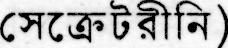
সেক্রেটরীনি)
